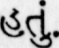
હતું.
